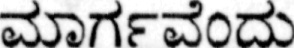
ಮಾರ್ಗವೆಂದು
